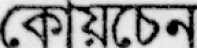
কোয়চেন
